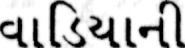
વાડિયાની
